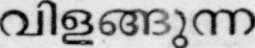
വിളങ്ങുന്ന
